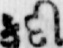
કદી
